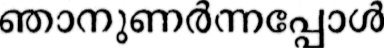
ഞാനുണര്‍ന്നപ്പോള്‍
